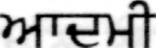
ਆਦਮੀ
